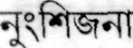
নুংশিজনা
